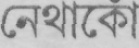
নেথাকোঁ
